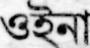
ওইনা
